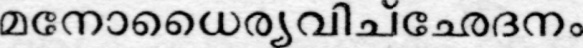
മനോധൈര്യവിച്ഛേദനം
